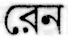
রেন
